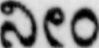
ನೀಂ
